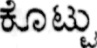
ಕೊಟ್ಟು
